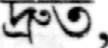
দ্রুত,
